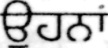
ਉਹਨਾਂ
